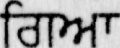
ਗਿਆ
